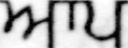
ਆਪ
